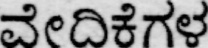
ವೇದಿಕೆಗಳ
